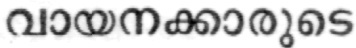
വായനക്കാരുടെ
